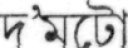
দ'মটো
